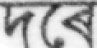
দৰে
